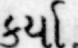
કર્યા.
